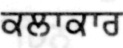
ਕਲਾਕਾਰ
